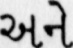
અને
